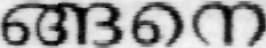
ങ്ങനെ
